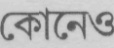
কোনেও
